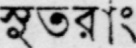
সুতরাং
